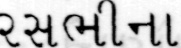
રસભીના
